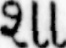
શા
